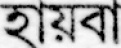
হায়বা
